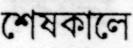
শেষকালে
